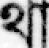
থা
